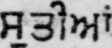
ਸੁਤੀਆਂ
